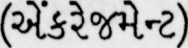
(એંકરેજમેન્ટ)
